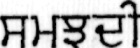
ਸਮਝਦੀ
